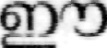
ഈ
